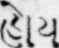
હોય
